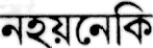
নহয়নেকি
